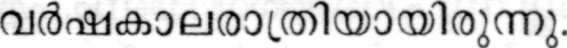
വര്‍ഷകാലരാത്രിയായിരുന്നു.
